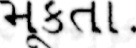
મૂકતા.
